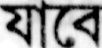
যাবে
